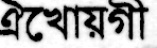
ঐখোয়গী
